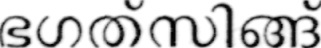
ഭഗത്സിങ്ങ്
